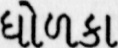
ધોળકા
